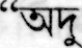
“অদু
